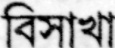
বিসাখা
